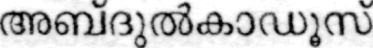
അബ്ദുല്‍കാഡൂസ്
